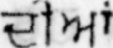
ਦੀਆਂ
